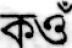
কওঁ
